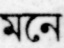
মনে
